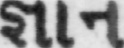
જ્ઞાન
